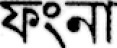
ফংনা
